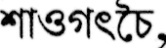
শাওগৎচৈ,
